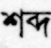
শব্দ
